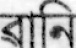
ৱানি
